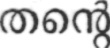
തന്റെ
